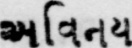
અવિનય
